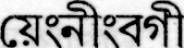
য়েংনীংবগী
